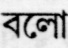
বলো
